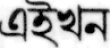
এইখন
